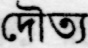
দৌত্য
